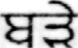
ਬੜੇ
